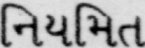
નિયમિત
